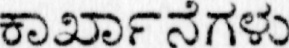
ಕಾರ್ಖಾನೆಗಳು
